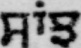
ਸਾਂਝ
